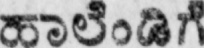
ಹಾಲೆಂಡಿಗೆ
